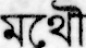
মথৌ
